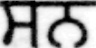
ਸਨ
